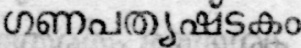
ഗണപത്യഷ്ടകം
